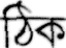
ঠিক
